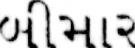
બીમાર
